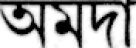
অমদা
